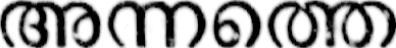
അന്നത്തെ
